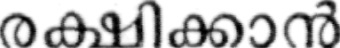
രക്ഷിക്കാന്‍
